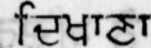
ਦਿਖਾਣਾ
